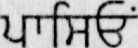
ਪਾਸਿਓਂ
